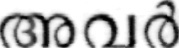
അവര്‍
